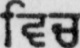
ਵਿਚ
